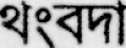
থংবদা
